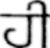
ਹੀ
